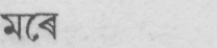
মৰে
